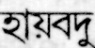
হায়বদু
